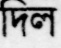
দিল
